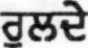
ਰੁਲਦੇ
